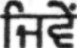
ਜਿਵੇਂ
